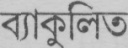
ব্যাকুলিত
